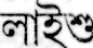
লাইশু
